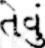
તેવું
